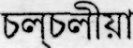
চল্‌চলীয়া
